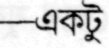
–একটু
